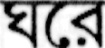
ঘরে
